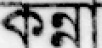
কন্না
